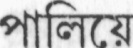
পালিয়ে
